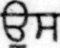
ਉਸ
